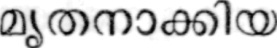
മൃതനാക്കിയ
